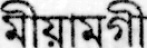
মীয়ামগী
